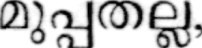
മുപ്പതല്ല,
